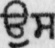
ਉਸ
